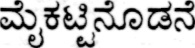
ಮೈಕಟ್ಟಿನೊಡನೆ
